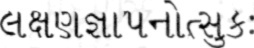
લક્ષણજ્ઞાપનોત્સુકઃ
